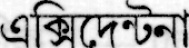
এক্সিদেন্টনা
